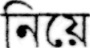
নিয়ে
